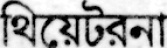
থিয়েটরনা
